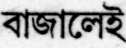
বাজালেই
